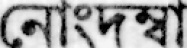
নোংদম্বা
